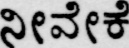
ನೀವೇಕೆ
